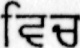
ਵਿਚ
